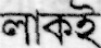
লাকই
